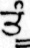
ਤੂੰ
